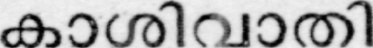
കാശിവാതി
